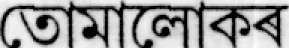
তোমালোকৰ
